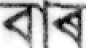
বাৰ
